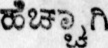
ಹೆಚ್ಚಾಗಿ
